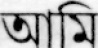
আমি
